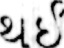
થઈ
